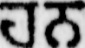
ਹਨ
